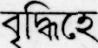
বৃদ্ধিহে
